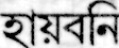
হায়বনি
